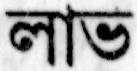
লাভ
